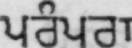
ਪਰੰਪਰਾ
